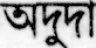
অদুদা
